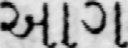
આગ
